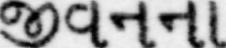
જીવનના
